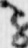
કે
